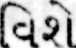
વિશે
